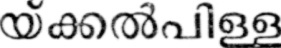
യ്ക്കല്‍പിള്ള
